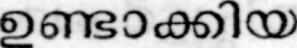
ഉണ്ടാക്കിയ
